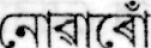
নোৱাৰোঁ
